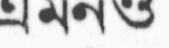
এমনও
